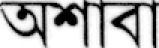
অশাবা
